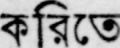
করিতে
